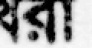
খরা
